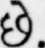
છે.
